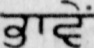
ਭਾਵੇਂ
